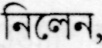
নিলেন,
